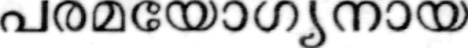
പരമയോഗ്യനായ
